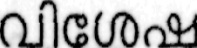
വിശേഷ
